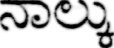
ನಾಲ್ಕು
